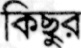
কিছুর
